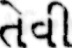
તેવી
